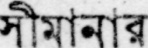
সীমানার
